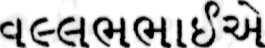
વલ્લભભાઈએ
